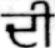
ਦੀ
